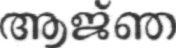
ആജ്ഞ
